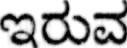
ಇರುವ
